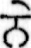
ਨੇ
